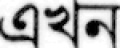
এখন
